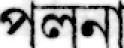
পলনা
